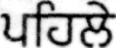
ਪਹਿਲੇ
